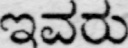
ಇವರು
